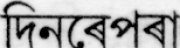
দিনৰেপৰা
